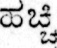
ಹಚ್ಚಿ
